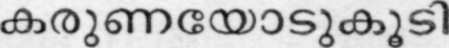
കരുണയോടുകൂടി
